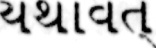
યથાવત્
